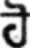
ਹੋ
